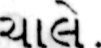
ચાલે.
